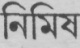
নিমিষ
